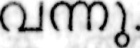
വന്നു.
